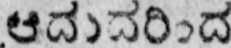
ಆದುದರಿಂದ
